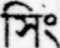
সিং
